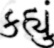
કહ્યું
